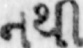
નથી
